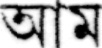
আম
